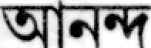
আনন্দ
